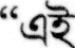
"এই
